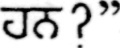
ਹਨ?''
